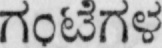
ಗಂಟೆಗಳ
